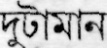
দুটামান
